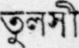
তুলসী
